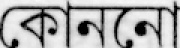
কোননো
